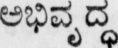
ಅಭಿವೃದ್ಧ
